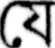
যে
